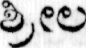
ಶ್ರೀಲ
